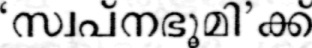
'സ്വപ്നഭൂമി'ക്ക്
